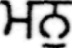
ਮਨੁ
